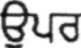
ਉਪਰ
